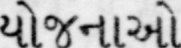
યોજનાઓ
